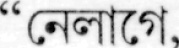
"নেলাগে,
